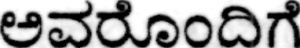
ಅವರೊಂದಿಗೆ
